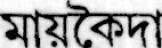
মায়কৈদা
